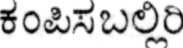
ಕಂಪಿಸಬಲ್ಲಿರಿ
